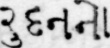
રુદનનો
